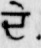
ਦੇ
